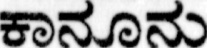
ಕಾನೂನು
